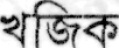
খজিক
